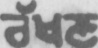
ਰੱਖਣ
